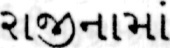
રાજીનામાં
